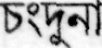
চংদুনা
